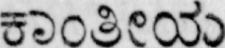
ಕಾಂತೀಯ
